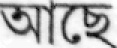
আছে
